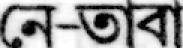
নে-তাবা
